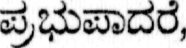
ಪ್ರಭುಪಾದರೆ,
